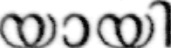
യായി
